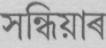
সন্ধিয়াৰ
